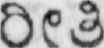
ರೀತಿ
